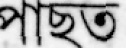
পাছত
